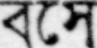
বসে
